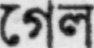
গেল
